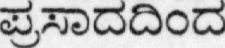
ಪ್ರಸಾದದಿಂದ
